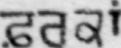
ਫ਼ਰਕਾਂ
